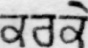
ਕਰਕੇ
